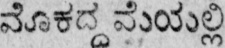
ಮೊಕದ್ದಮೆಯಲ್ಲಿ
